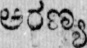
ಅರಣ್ಯ
